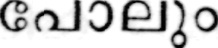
പോലും
